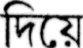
দিয়ে
